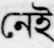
নেই
